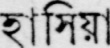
হাসিয়া
